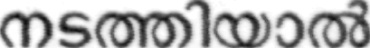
നടത്തിയാല്‍
